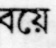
বয়ে
